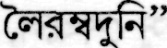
লৈরম্বদুনি”
